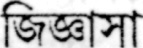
জিজ্ঞাসা
